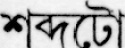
শব্দটো
